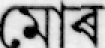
মোৰ
